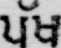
ਪੱਖ
